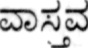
ವಾಸ್ತವ
